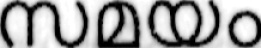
സമയം
